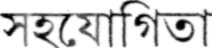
সহযোগিতা
